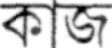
কাজ
